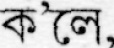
ক'লে,
